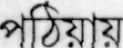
পঠিয়ায়
